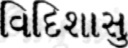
વિદિશાસુ
